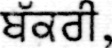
ਬੱਕਰੀ,
